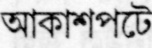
আকাশপটে
